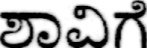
ಶಾವಿಗೆ
